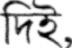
দিই,
